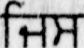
ਜਿਸ
